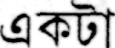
একটা
